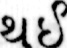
થઈ
